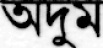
অদুম
